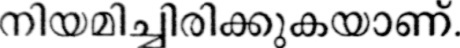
നിയമിച്ചിരിക്കുകയാണ്.
